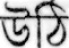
উঠি
